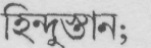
হিন্দুস্তান;
